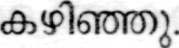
കഴിഞ്ഞു.
